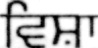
ਵਿਸ਼ਾ
